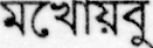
মখোয়বু
